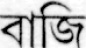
বাজি
